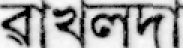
ৱাখলদা
